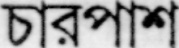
চারপাশ
